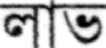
লাভ
